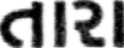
તારા
